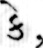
કે,
